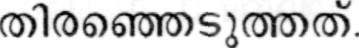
തിരഞ്ഞെടുത്തത്.
